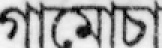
গামোচা
